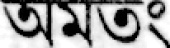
অমতং
